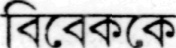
বিবেককে
